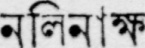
নলিনাক্ষ
